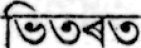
ভিতৰত
